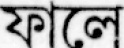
ফালে
